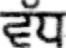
ਵੱਧ
